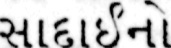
સાદાઈનો
